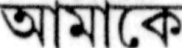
আমাকে
